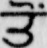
ਤੋਂ
